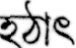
হঠাৎ
